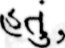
હતું,
